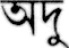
অদু
